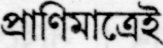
প্রাণিমাত্রেই
